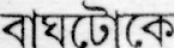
বাঘটোকে
